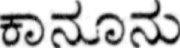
ಕಾನೂನು
